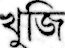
খুজি
